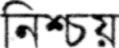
নিশ্চয়
